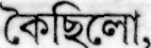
কৈছিলো,
